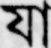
যা
